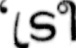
‘ട്രീ
